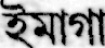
ইমাগা
